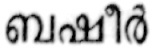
ബഷീര്‍
